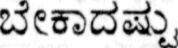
ಬೇಕಾದಷ್ಟು
